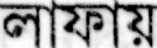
লাফায়
